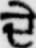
ਦੇ
